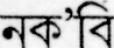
নক'বি
